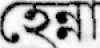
হেন্না
